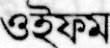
ওইফম
